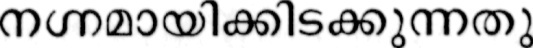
നഗ്നമായിക്കിടക്കുന്നതു
